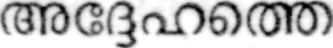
അദ്ദേഹത്തെ
